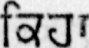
ਕਿਹਾ
